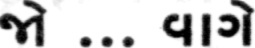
જો.....વાગે
